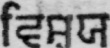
ਵਿਸ਼ਯ
